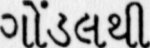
ગોંડલથી
